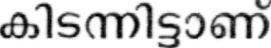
കിടന്നിട്ടാണ്
